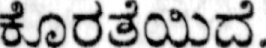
ಕೊರತೆಯಿದೆ.
